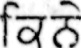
ਕਿਨੇ
